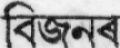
বিজনৰ
